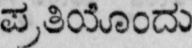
ಪ್ರತಿಯೊಂದು
